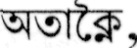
অতাক্নৈ,
